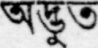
অদ্ভুত
